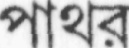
পাথর
